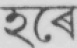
হৰে
